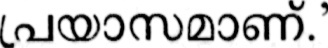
പ്രയാസമാണ്.’
